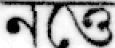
নত্তে
